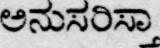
ಅನುಸರಿಸ್ತಾ
